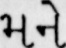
મને
